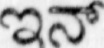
ಇನ್
